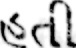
હતી
